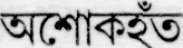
অশোকহঁত
